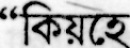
"কিয়হে
